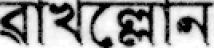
ৱাখল্লোন
